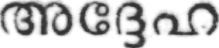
അദ്ദേഹ
